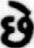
છે
